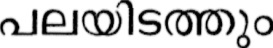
പലയിടത്തും
